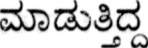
ಮಾಡುತ್ತಿದ್ದ
